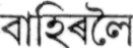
বাহিৰলৈ
